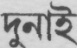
দুনাই
